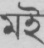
মই
